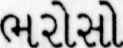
ભરોસો
